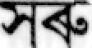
সৰু
